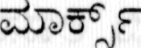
ಮಾರ್ಕ್ಸ್
